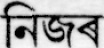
নিজৰ
